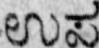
ಉಪ
